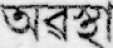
অৱস্হা
